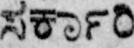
ಸರ್ಕಾರಿ
